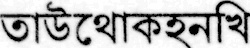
তাউথোকহনখি
